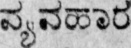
ವ್ಯವಹಾರ
